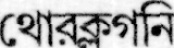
থোরক্লগনি
